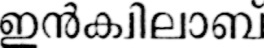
ഇന്‍ക്വിലാബ്
